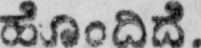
ಹೊಂದಿದೆ.
